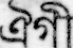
ঐগী
